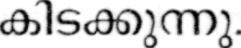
കിടക്കുന്നു.
